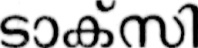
ടാക്സി
